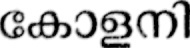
കോളനി
